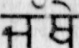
ਜੱਥੇ
